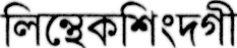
লিন্থেকশিংদগী
